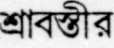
শ্রাবস্তীর
